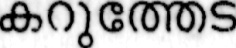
കറുത്തേട
